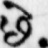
છે.
